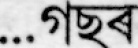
...গছৰ
